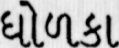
ધોળકા
